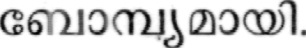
ബോമ്പ്യമായി.
